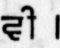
ਵੀ।
